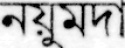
নয়ুমদা
